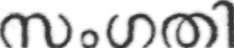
സംഗതി
